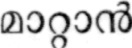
മാറ്റാന്‍
